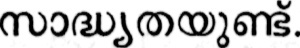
സാദ്ധ്യതയുണ്ട്.
